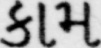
કામ
